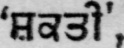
'ਸ਼ਕਤੀ',
